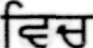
ਵਿਚ
